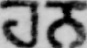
ਹਨ
